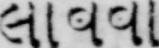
લાવવા
